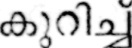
കുറിച്ച്
